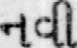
નવી
